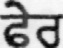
ਫੇਰ
